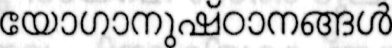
യോഗാനുഷ്ഠാനങ്ങള്‍
